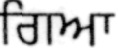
ਗਿਆ
